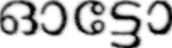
ഓട്ടോ
